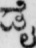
ಡೈ
